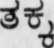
ತಕ್ಕ
